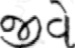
જીવે
